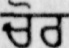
ਚੋਰ
